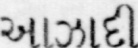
આઝાદી
